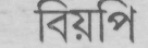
বিয়পি
